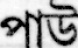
পাউ
